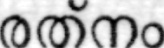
രത്നം
